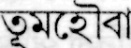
তূমহৌবা
